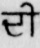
ਦੀ
